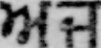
ਅਜ
